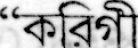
“করিগী
